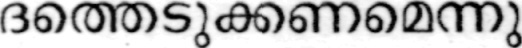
ദത്തെടുക്കണമെന്നു
